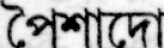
পৈশাদো
